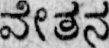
ವೇತನ
